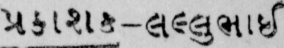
પ્રકાશક-લલ્લુભાઈ
